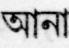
আনা
